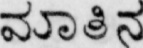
ಮಾತಿನ
